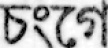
চংগে
